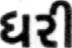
ધરી
